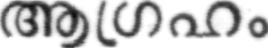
ആഗ്രഹം
